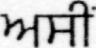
ਅਸੀਂ
